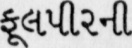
ફૂલપીરની
